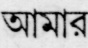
আমার
